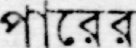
পারের
